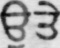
ਉਤੇ
